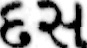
દસ
